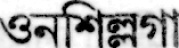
ওনশিল্লগা
